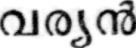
വര്യന്‍
